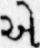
એ
